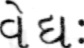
વેદ્યઃ
